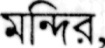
মন্দির,
